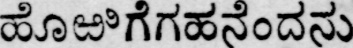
ಹೊಱಿಗೆಗಹನೆಂದನು
